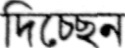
দিচ্ছেন
